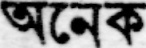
অনেক
